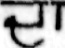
ਦਾ
